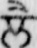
ਲੈ
